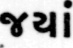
જ્યાં
